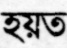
হয়ত
